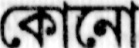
কোনো
